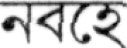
নবহে
